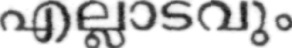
എല്ലാടവും
